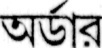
অর্ডার
